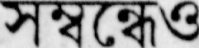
সম্বন্ধেও
